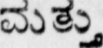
ಮತ್ತು
